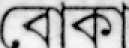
বোকা
